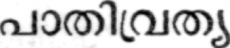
പാതിവ്രത്യ
